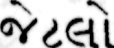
જેટલો
